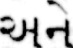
અને
